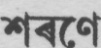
শৰণে
